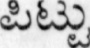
ಪಿಟ್ಟು
